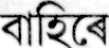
বাহিৰে
